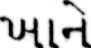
ખાને
